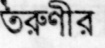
তরুণীর
